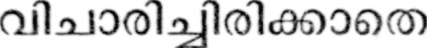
വിചാരിച്ചിരിക്കാതെ
